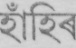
হাঁহিৰ
